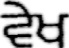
ਵੇਖ
